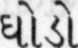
ઘોડો
